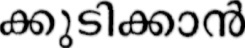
ക്കുടിക്കാന്‍
